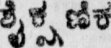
ಶೈಕ್ಷಣಿಕ
